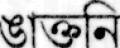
ঙাক্তনি
